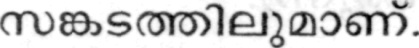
സങ്കടത്തിലുമാണ്.
